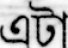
এটা
